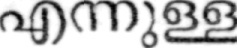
എന്നുള്ള
